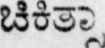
ಚಿಕಿತ್ಸಾ
